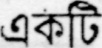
একটি
